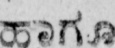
ಹಾಗೂ
